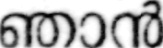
ഞാന്‍
